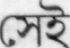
সেই
